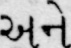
અને
